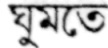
ঘুমতে
